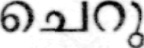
ചെറു
